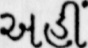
અહીં
